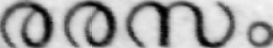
രരസം
